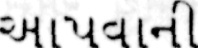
આપવાની
